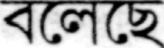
বলেছে
